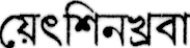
য়েৎশিনখ্রবা
